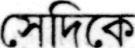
সেদিকে
